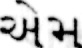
એમ
